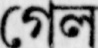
গেল
